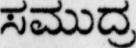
ಸಮುದ್ರ
